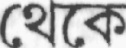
থেকে
